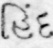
હિંદ
